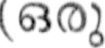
(ഒരു
